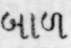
બાળ
